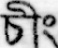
চীং
